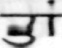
ਤਾਂ
